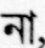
না,
